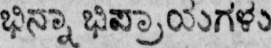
ಭಿನ್ನಾಭಿಪ್ರಾಯಗಳು
